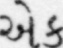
એક
